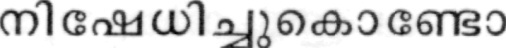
നിഷേധിച്ചുകൊണ്ടോ
